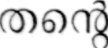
തന്റെ
